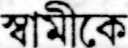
স্বামীকে
